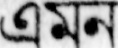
এমন
